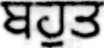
ਬਹੁਤ
